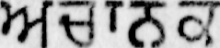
ਅਚਾਨਕ
